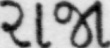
રાજા
